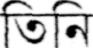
তিনি
